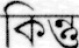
কিন্তু
